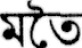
মতৈ
